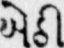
બેઠી
